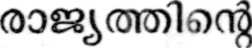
രാജ്യത്തിന്റെ
